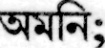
অমনি;
